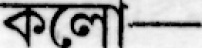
কলো-
